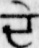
ਦੇ
